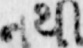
નથી
